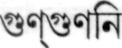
গুণ্‌গুণনি
